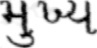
મુખ્ય
